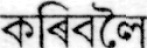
কৰিবলৈ
